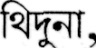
থিদুনা,
